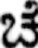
ಚೆ
